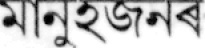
মানুহজনৰ
